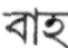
বাহ
